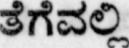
ತೆಗೆವಲ್ಲಿ
